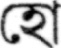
হো
